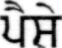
ਪੈਸੇ
